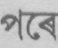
পৰে
